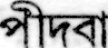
পীদবা
